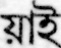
য়াই
